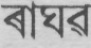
ৰাঘৱ
